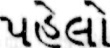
પહેલો
